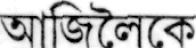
আজিলৈকে
